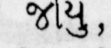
જોયું,
